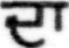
ਦਾ
